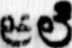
ಅಲೆ
